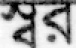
স্বর
